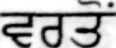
ਵਰਤੋਂ
